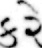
કરે
